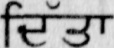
ਦਿੱਤਾ
